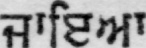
ਜਾਇਆ
